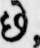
છે,
